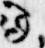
છે,
